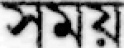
সময়
